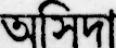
অসিদা
